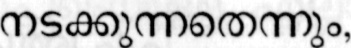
നടക്കുന്നതെന്നും,
